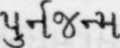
પુર્નજન્મ
